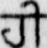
ਹੀ
